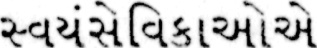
સ્વયંસેવિકાઓએ
